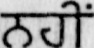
ਨਹੀਂ
